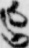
હું
